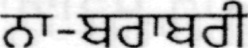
ਨਾ-ਬਰਾਬਰੀ
